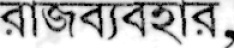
রাজব্যবহার,
